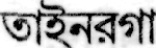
তাইনরগা
